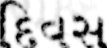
દિવસ
